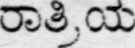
ರಾತ್ರಿಯ
